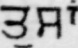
ਤੁਸਾਂ
